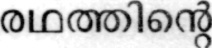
രഥത്തിന്റെ
